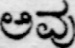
ಅವು
